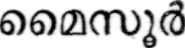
മൈസൂര്‍
